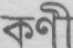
কণী
